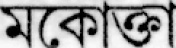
মকোক্তা
